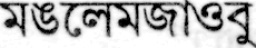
মঙলেমজাওবু
